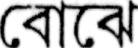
বোঝে
